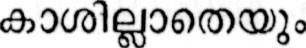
കാശില്ലാതെയും
